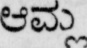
ಆಮ್ಲ
